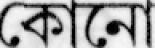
কোনো
